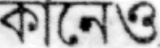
কানেও
